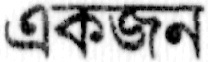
একজন
